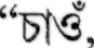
"চাওঁ,
